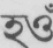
হওঁ
